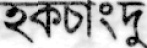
হকচাংদু
